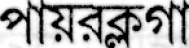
পায়রক্লগা
